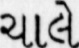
ચાલે
